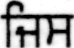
ਜਿਸ
